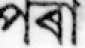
পৰা
